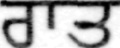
ਰਾਤ
